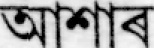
আশাৰ
